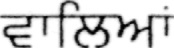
ਵਾਲਿਆਂ
